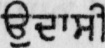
ਉਦਾਸੀ
